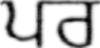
ਪਰ
